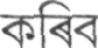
কৰিব
